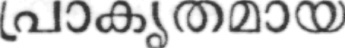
പ്രാകൃതമായ
